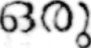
ഒരു
